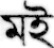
মই
